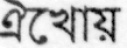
ঐখোয়
